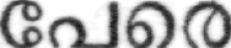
പേരെ
